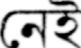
নেই
